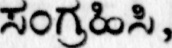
ಸಂಗ್ರಹಿಸಿ,
